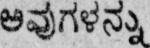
ಅವುಗಳನ್ನು
